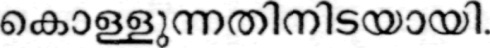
കൊള്ളുന്നതിനിടയായി.
